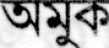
অমুক
